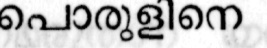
പൊരുളിനെ
